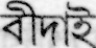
বীদাই
